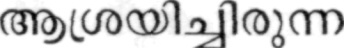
ആശ്രയിച്ചിരുന്ന
